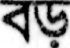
বড়
